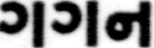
ગગન
